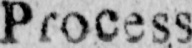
Process
